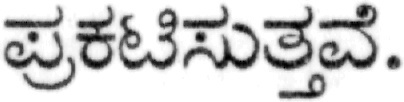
ಪ್ರಕಟಿಸುತ್ತವೆ.
